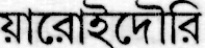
য়ারোইদৌরি
